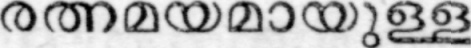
രത്നമയമായുള്ള
